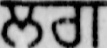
ਲਗ
